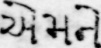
એમને
